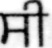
ਸੀ
